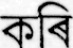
কৰি
